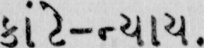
કાંટે-ન્યાય.
